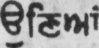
ਉਣਿਆਂ
